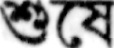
শুষে
